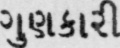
ગુણકારી
